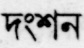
দংশন
